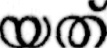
യത്
